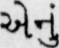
એનું
